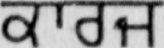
ਕਾਰਜ
